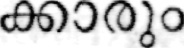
ക്കാരും
